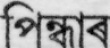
পিন্ধাৰ
